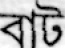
বাট
